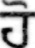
ਹੋ
